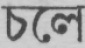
চলে
